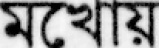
মখোয়
